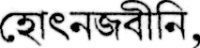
হোৎনজবীনি,
